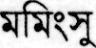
মমিংসু
